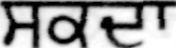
ਸਕਦਾ
